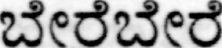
ಬೇರೆಬೇರೆ
